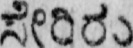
ಸೇರಿರು
